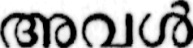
അവള്‍
